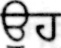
ਉਹ
